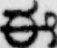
ಈ
